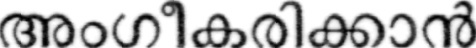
അംഗീകരിക്കാന്‍
